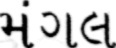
મંગલ
